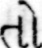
તો
